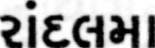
રાંદલમા
